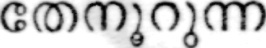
തേനൂറുന്ന
